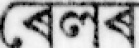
ৰেলৰ
